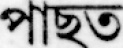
পাছত
